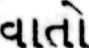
વાતો
